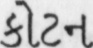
કોટન
